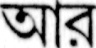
আর
